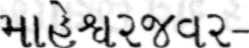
માહેશ્વરજવર-
